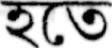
হতে
